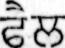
ਫੈਲ
